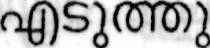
എടുത്തു
